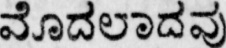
ಮೊದಲಾದವು
